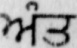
ਅੰਤ
